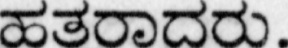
ಹತರಾದರು.
